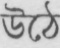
উঠে
